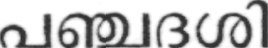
പഞ്ചദശി
